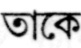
তাকে
